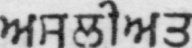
ਅਸਲੀਅਤ
